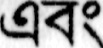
এবং
